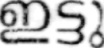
ഇട്ടു
